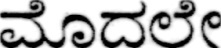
ಮೊದಲೇ
